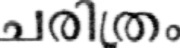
ചരിത്രം
